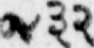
જરૂર
